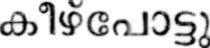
കീഴ്പോട്ടു
